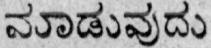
ಮಾಡುವುದು
